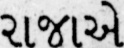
રાજાએ
